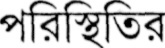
পরিস্থিতির
